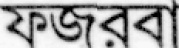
ফজরবা
